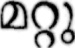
മറ്റു
